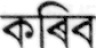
কৰিব
